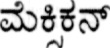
ಮೆಕ್ಸಿಕನ್
